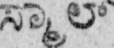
ಸ್ಮಾಲ್
